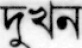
দুখন
